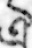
ঐ
